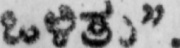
ಒಳಿತು”.
